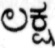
ಲಕ್ಷ
